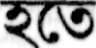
হতে
